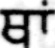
ਥਾਂ
